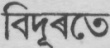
বিদূৰতে
